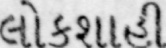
લોકશાહી
